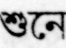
শুনে
